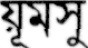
য়ূমসু
